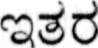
ಇತರ
